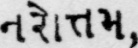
નરોત્તમ,
